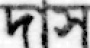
দাস
